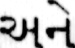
અને
